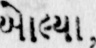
બોલ્યા,
